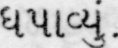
ધપાવ્યું.
